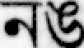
নঙ
